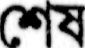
শেষ
